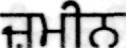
ਜ਼ਮੀਨ
